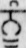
ਨੂੰ
